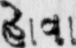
હોવા
